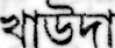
খাউদা
